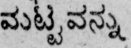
ಮಟ್ಟವನ್ನು
